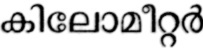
കിലോമീറ്റര്‍
